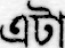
এটা
